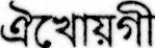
ঐখোয়গী
